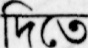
দিতে
